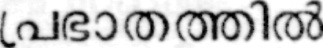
പ്രഭാതത്തില്‍
